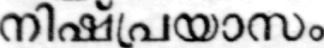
നിഷ്പ്രയാസം
